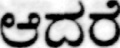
ಆದರೆ
